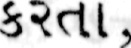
કરતા,
